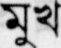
মুখ
